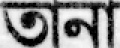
তানা
